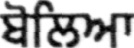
ਬੋਲਿਆ
